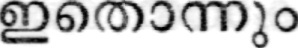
ഇതൊന്നും
